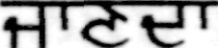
ਜਾਣਦਾ
